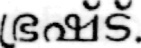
ഭ്രഷ്ട്.
